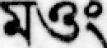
মওং
